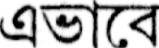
এভাবে
